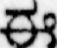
ಈ
